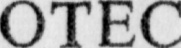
OTEC
